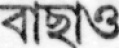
বাছাও
